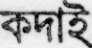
কদাই
